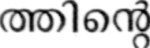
ത്തിന്റെ
